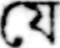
যে
